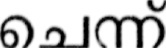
ചെന്ന്
